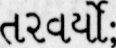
તરવર્યો;
